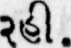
રહી.
